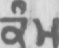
ਕੰਮ
